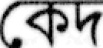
কেদ
